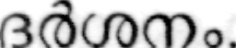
ദര്‍ശനം.
